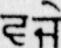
ਵਜੇ
